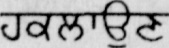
ਹਕਲਾਉਣ
